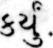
કર્યું.
